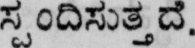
ಸ್ಪಂದಿಸುತ್ತದೆ.
